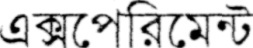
এক্সপেরিমেন্ট
